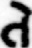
તે
